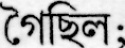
গৈছিল;
